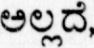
ಅಲ್ಲದೆ,
